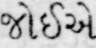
જોઈએ
